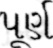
પૂર્ણ
